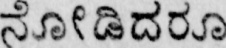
ನೋಡಿದರೂ
